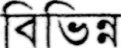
বিভিন্ন
